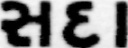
સદા
